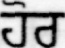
ਹੋਰ
